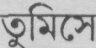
তুমিসে
